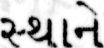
સ્થાને
